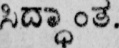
ಸಿದ್ಧಾ೦ತ.
